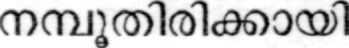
നമ്പൂതിരിക്കായി
